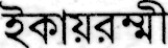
ইকায়রম্মী
